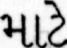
માટે
